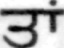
ਤਾਂ
